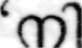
‘നി
